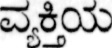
ವ್ಯಕ್ತಿಯ
